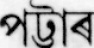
পট্টাৰ
